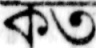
কত
